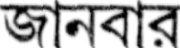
জানবার
